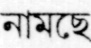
নামছে
